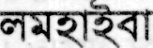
লমহাইবা
